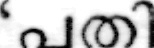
‘പതി
